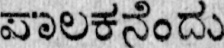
ಪಾಲಕನೆಂದು
